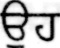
ਉਹ
